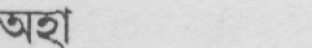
অহা
